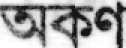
অকণ
